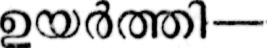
ഉയര്‍ത്തി-
